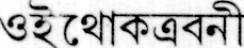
ওইথোকত্রবনী
